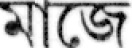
মাজে
